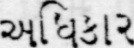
અધિકાર
